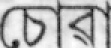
চোৱা
